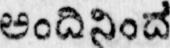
ಅಂದಿನಿಂದ
